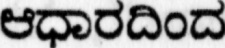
ಆಧಾರದಿಂದ
